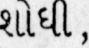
શોધી,
